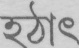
হঠাৎ
